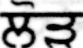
ਲੋੜ
